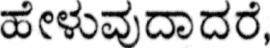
ಹೇಳುವುದಾದರೆ,
